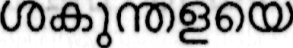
ശകുന്തളയെ
